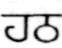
ਹਠ
